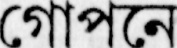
গোপনে
